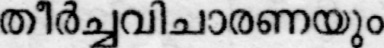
തീര്‍ച്ചവിചാരണയും
